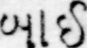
બાઈ
